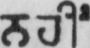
ਨਹੀਂ
